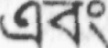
এবং
